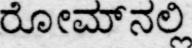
ರೋಮ್‌ನಲ್ಲಿ
